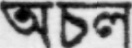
অচল
